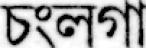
চংলগা
